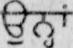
ਉਨ੍ਹਾਂ
